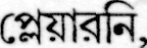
প্লেয়ারনি,
